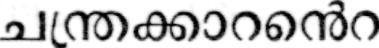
ചന്ത്രക്കാറന്റെ
